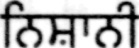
ਨਿਸ਼ਾਨੀ
